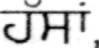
ਹੱਸਾਂ,
